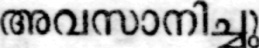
അവസാനിച്ചു
